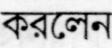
করলেন
